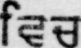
ਵਿਚ
